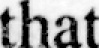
that
